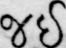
જઈ
